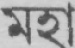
মহা
